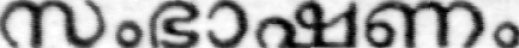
സംഭാഷണം
